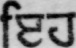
ਇਹ
